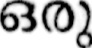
ഒരു
